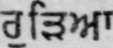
ਰੁੜਿਆ
